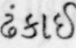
ઢંકાઈ
